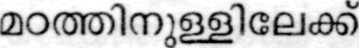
മഠത്തിനുള്ളിലേക്ക്
